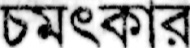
চমৎকার
